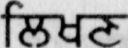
ਲਿਖਣ
